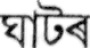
ঘাটৰ
